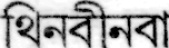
থিনবীনবা
